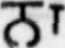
ਨਾ
